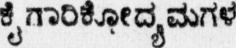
ಕೈಗಾರಿಕೋದ್ಯಮಗಳ
